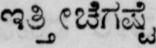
ಇತ್ತೀಚೆಗೆಷ್ಟೆ
